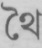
থৈ
